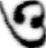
ও
